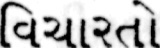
વિચારતો
